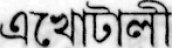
এখোটালী
